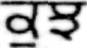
ਕੁਝ
